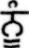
ਨੂੰ
